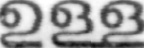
ഉള്ള
